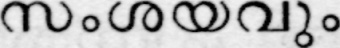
സംശയവും
